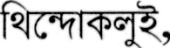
থিন্দোকলুই,
